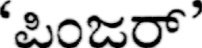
'ಪಿಂಜರ್'
